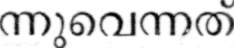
ന്നുവെന്നത്
